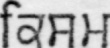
ਕਿਸਮ
